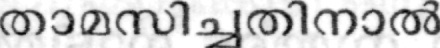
താമസിച്ചതിനാല്‍
